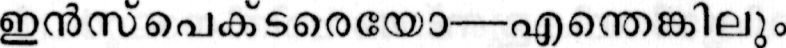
ഇന്‍സ്പെക്ടരെയോ-എന്തെങ്കിലും
